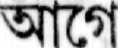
আগে
